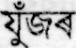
যুঁজৰ
